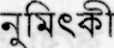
নুমিৎকী
